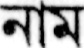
নাম
